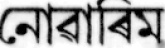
নোৱাৰিম
